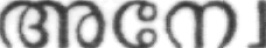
അന്വേ
